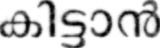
കിട്ടാന്‍
